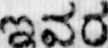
ಇವರ
